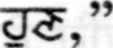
ਹੁਣ,''
